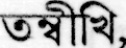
তম্বীখি,
